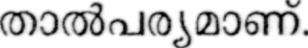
താല്‍പര്യമാണ്.
